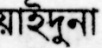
য়াইদুনা
